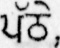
ਪੱਠੇ,
